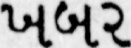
ખબર
